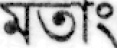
মতাং
